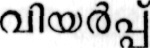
വിയര്‍പ്പ്
